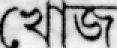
খোজ
